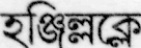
হঞ্জিল্লক্লে
